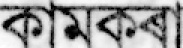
কামকৰা
